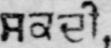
ਸਕਦੀ,
